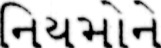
નિયમોને
